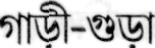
গাড়ী-গুড়া
